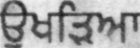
ਉਖੜਿਆ
